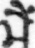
ਮੈਂ
